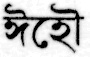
ঈহৌ
